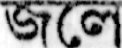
জলে
